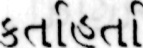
કર્તાહર્તા
